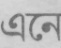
এনে
